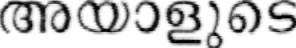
അയാളുടെ
